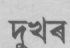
দুখৰ
